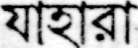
যাহারা
